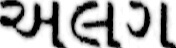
અલગ
